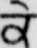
ਕੇ
